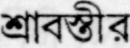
শ্রাবস্তীর
